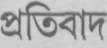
প্ৰতিবাদ
